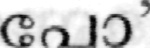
പോ'
